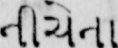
નીચેના
